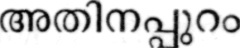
അതിനപ്പുറം
